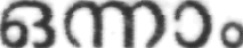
ഒന്നാം
